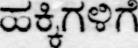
ಹಕ್ಕಿಗಳಿಗೆ
